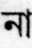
না
